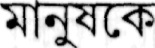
মানুষকে
